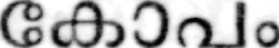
കോപം
